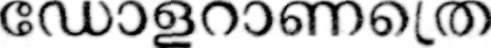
ഡോളറാണത്രെ
